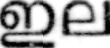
ഇല
